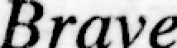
Brave
